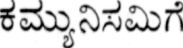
ಕಮ್ಯುನಿಸಮಿಗೆ
